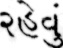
રહેવું
